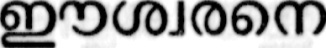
ഈശ്വരനെ
